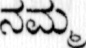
ನಮ್ಮ
